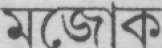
মজোক
